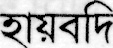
হায়বদি
